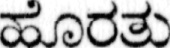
ಹೊರತು
